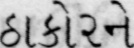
ઠાકોરને
